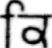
ਕਿ
